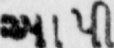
આપી
